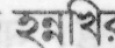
হন্নখির
